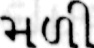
મળી
